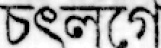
চৎলগে
